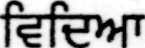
ਵਿਦਿਆ
